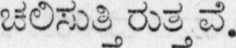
ಚಲಿಸುತ್ತಿರುತ್ತವೆ.
